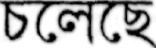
চলেছে
